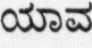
ಯಾವ
